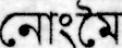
নোংমৈ
